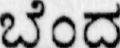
ಬೆಂದ
